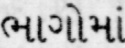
ભાગોમાં
